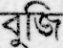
বুজি
